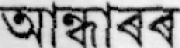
আন্ধাৰৰ
